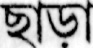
ছাড়া
